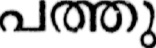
പത്തു
